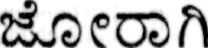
ಜೋರಾಗಿ
